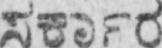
ಸರ್ಕಾರ
